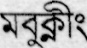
মবুক্নীং
